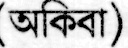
(অকিবা)
